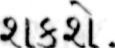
શકશે.
